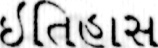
ઈતિહાસ
